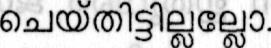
ചെയ്തിട്ടില്ലല്ലോ.
